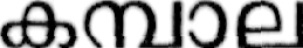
കമ്പാല
